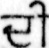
ਦੀ
